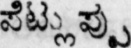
ಪೆಟ್ಲುಪ್ಪು
